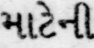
માટેની
